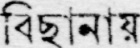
বিছানায়
